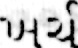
ખર્ચ
